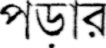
পড়ার
